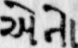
એનો
